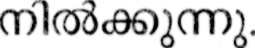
നില്‍ക്കുന്നു.
